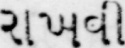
રાખવી
